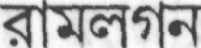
রামলগন
